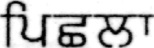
ਪਿਛਲਾ
